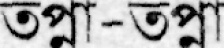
তপ্না-তপ্না
